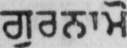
ਗੁਰਨਾਮੋ
